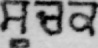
ਸੂਚਕ
